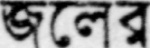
জলের
